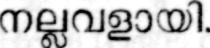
നല്ലവളായി.
